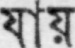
যায়
